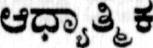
ಆಧ್ಯಾತ್ಮಿಕ
